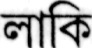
লাকি
